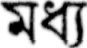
মধ্য
